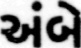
અંબે
